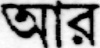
আর
